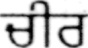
ਚੀਰ
